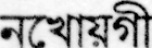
নখোয়গী
